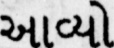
આવ્યો
